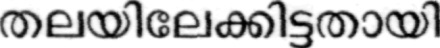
തലയിലേക്കിട്ടതായി
